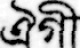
ঐগী
